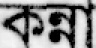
কন্না
